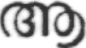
ആ
